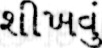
શીખવું
